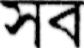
সব
